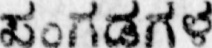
ಪಂಗಡಗಳ
